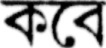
কবে
